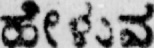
ಹೇಳುವ
